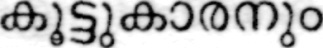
കൂട്ടുകാരനും
